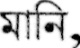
মানি,
